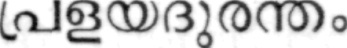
പ്രളയദുരന്തം
